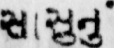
સાસુનું
